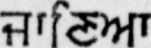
ਜਾਣਿਆ
